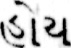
હોય
